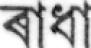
ৰাধা
